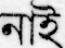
নাই
